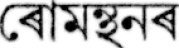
ৰোমন্থনৰ
